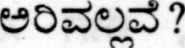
ಅರಿವಲ್ಲವೆ?
